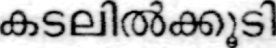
കടലില്‍ക്കൂടി
